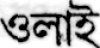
ওলাই
